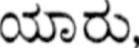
ಯಾರು,
